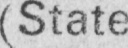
(State
